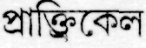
প্রাক্তিকেল
